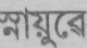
স্নায়ুৱে
